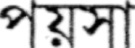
পয়সা
